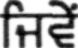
ਜਿਵੇਂ
